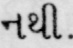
નથી.
